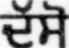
ਦੱਸੋ
